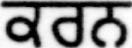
ਕਰਨ
